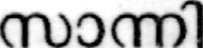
സാന്നി
